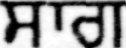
ਸਾਗ
